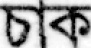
চাক
